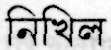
নিখিল
